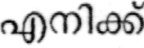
എനിക്ക്
